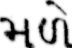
મળે
